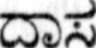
ದಾಸ
